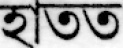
হাতত
